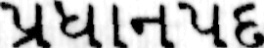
પ્રધાનપદ
